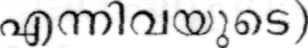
എന്നിവയുടെ)
